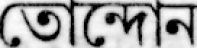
তোন্দোন
